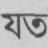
যত
